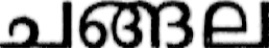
ചങ്ങല
